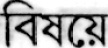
বিষয়ে
